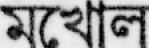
মখোল
